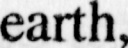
earth,
